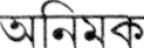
অনিমক
